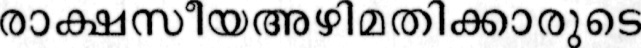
രാക്ഷസീയഅഴിമതിക്കാരുടെ
